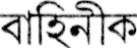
বাহিনীক
